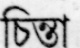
চিন্তা
